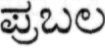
ಪ್ರಬಲ
